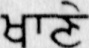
ਖਾਣੇ
